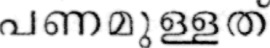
പണമുള്ളത്
